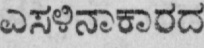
ಎಸಳಿನಾಕಾರದ
